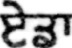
ਏਡਾ
